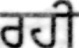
ਰਹੀ
